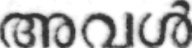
അവള്‍
